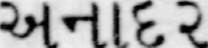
અનાદર
